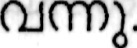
വന്നു.
